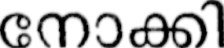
നോക്കി
